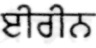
ਈਰੀਨ
